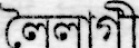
লৈলাগী
